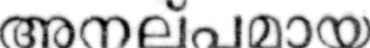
അനല്പമായ
